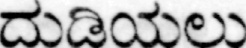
ದುಡಿಯಲು
